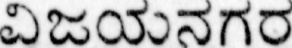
ವಿಜಯನಗರ
